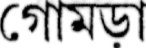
গোমড়া
